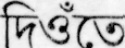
দিওঁতে
